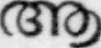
ആ
